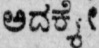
ಅದಕ್ಕೇ
